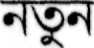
নতুন
